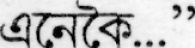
এনেকৈ..."
